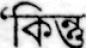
'কিন্তু
